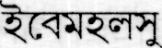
ইবেমহলসু
